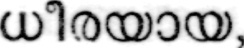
ധീരയായ,
